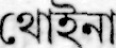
থোইনা
